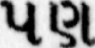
પણ
